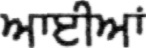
ਆਈਆਂ
